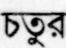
চতুর
